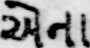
એના
